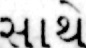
સાથે
